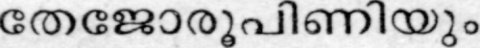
തേജോരൂപിണിയും
